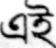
এই
